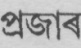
প্ৰজাৰ
